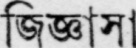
জিজ্ঞাসা
